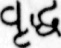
વૃદ્ધ
